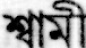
শ্বামী
